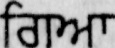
ਗਿਆ
